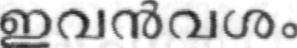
ഇവന്‍വശം
